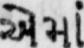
એમાં
